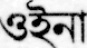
ওইনা
